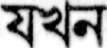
যখন
